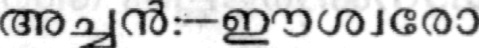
അച്ചന്‍:-ഈശ്വരോ
